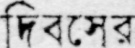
দিবসের
